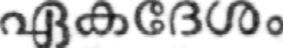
ഏകദേശം
